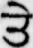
ਤੇ
